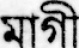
মাগী
